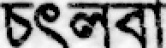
চৎলবা
